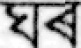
ঘৰ
